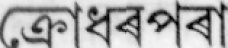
ক্রোধৰপৰা
